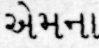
એમના
